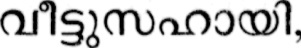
വീട്ടുസഹായി,
